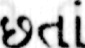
છતાં
